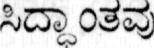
ಸಿದ್ಧಾಂತವು
